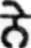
ਨੇ
